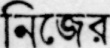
নিজের
